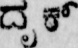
ದೃಕ್
